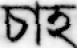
চাহ
